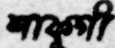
শাফূগী
